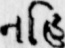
નહિ
